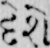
દેશે
